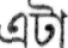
এটা
